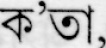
ক'তা,
